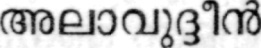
അലാവുദ്ദീന്‍
